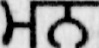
ਮਨ
